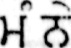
ਮੰਨੇ
